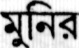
মুনির
